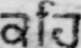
ਕਹਿ
